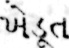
ખેડૂત
